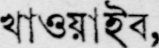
খাওয়াইব,
